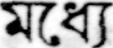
মধ্যে
